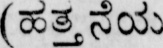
(ಹತ್ತನೆಯ
